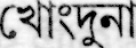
খোংদুনা
